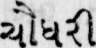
ચૌધરી
